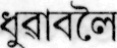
ধুৱাবলৈ
